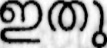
ഇതു
